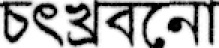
চৎখ্রবনো
